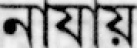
নাযায়
